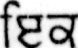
ਇਕ
